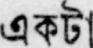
একটা
